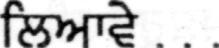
ਲਿਆਵੇ...
